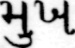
મુખ
